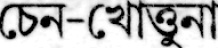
চেন-খোত্তুনা
